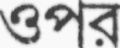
ওপর
